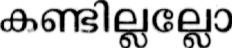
കണ്ടില്ലല്ലോ
